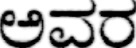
ಅವರ
